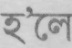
হ'লে
